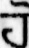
ਹੋ
